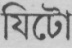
যিটো
